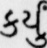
કર્યું
